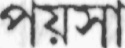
পয়সা
